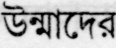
উন্মাদের
